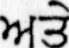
ਅਤੇ
